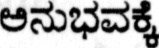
ಅನುಭವಕ್ಕೆ
